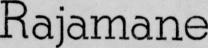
Rajamane
